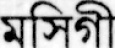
মসিগী
